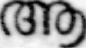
ആ
